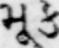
મૂક
